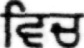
ਵਿਚ
